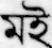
মই
